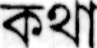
কথা
